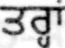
ਤਰ੍ਹਾਂ
